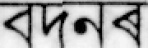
বদনৰ
